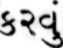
કરવું
